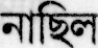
নাছিল
